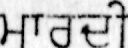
ਮਾਰਦੀ
